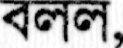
বলল,
